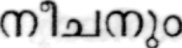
നീചനും
